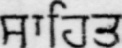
ਸਾਹਿਤ
